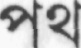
পথ
